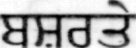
ਬਸ਼ਰਤੇ
